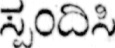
ಸ್ಪಂದಿಸಿ
